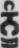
ਨੂੰ
